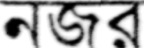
নজর
